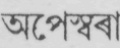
অপেস্বৰা
